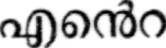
എന്റെ
